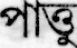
পাত্তু
